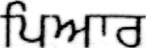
ਪਿਆਰ
